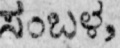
ಸಂಬಳ,
